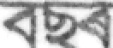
বছৰ
